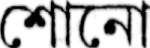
শোনো
